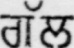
ਗੱਲ
